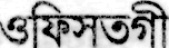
ওফিসতগী
